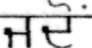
ਜਦੋਂ
